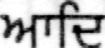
ਆਦਿ
